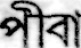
পীবা
